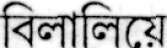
বিলালিয়ে
